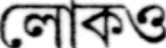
লোকও
